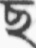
ছ
